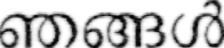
ഞങ്ങള്‍
